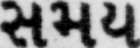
સમય
